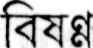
বিষণ্ণ
